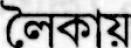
লৈকায়
